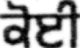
ਕੋਈ
